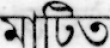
মাটিত
